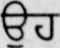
ਉਹ
